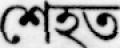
শেহত
